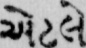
એટલે
